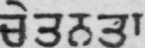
ਚੇਤਨਤਾ
